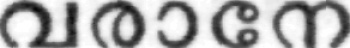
വരാനേ
